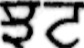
ਝਟ
